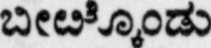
ಬೀೞ್ಕೊಂಡು
